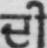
ਦੀ
